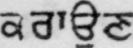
ਕਰਾਉਣ
